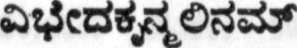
ವಿಭೇದಕೃನ್ಮಲಿನಮ್
